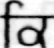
ਕਿ
